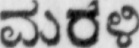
ಮರಳಿ
